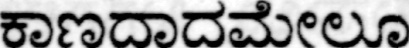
ಕಾಣದಾದಮೇಲೂ
